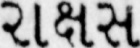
રાક્ષસ
